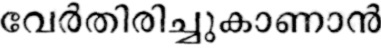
വേര്‍തിരിച്ചുകാണാന്‍
